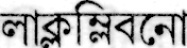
লাক্লম্লিবনো
